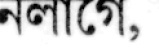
নলাগে,
